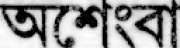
অশেংবা
